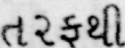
તરફથી
